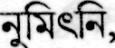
নুমিৎনি,
